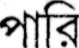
পারি
